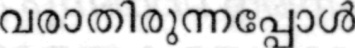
വരാതിരുന്നപ്പോള്‍
